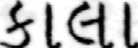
કાલા
